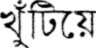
খুঁটিয়ে
